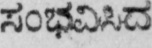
ಸಂಭವಿಸಿದ
